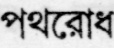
পথরোধ
